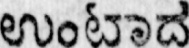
ಉಂಟಾದ
